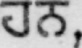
ਹਨ,
